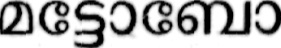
മട്ടോബോ
